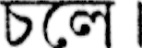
চলে।
